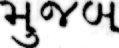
મુજબ
